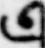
এ
